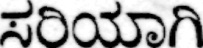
ಸರಿಯಾಗಿ
